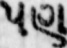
પણ
